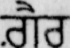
ਗ਼ੈਰ
